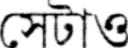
সেটাও
